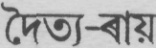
দৈত্য-ৰায়
